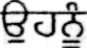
ਉਹਨੂੰ
